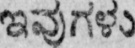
ಇವುಗಳು
